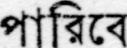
পারিবে
